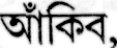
আঁকিব,
